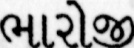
ભારોજી
